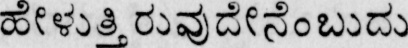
ಹೇಳುತ್ತಿರುವುದೇನೆಂಬುದು
